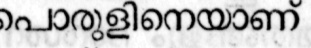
പൊരുളിനെയാണ്
